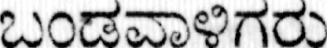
ಬಂಡವಾಳಿಗರು
